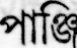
পাঞ্জি
